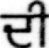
ਦੀ
